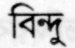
বিন্দু
